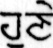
ਹੁਣੇ
